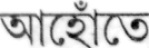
আহোঁতে
